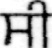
ਸੀ
